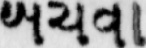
બચવા
